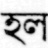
হল
